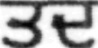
ਤਦ
